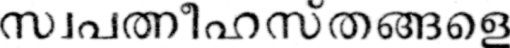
സ്വപത്നീഹസ്തങ്ങളെ
